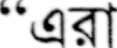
“এরা
